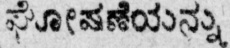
ಘೋಷಣೆಯನ್ನು
